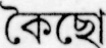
কৈছো
